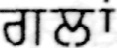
ਗਲਾਂ
